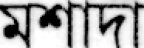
মশাদা
